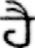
ਹੈ
